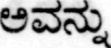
ಅವನ್ನು
